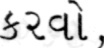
કરવો,
